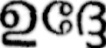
ഉദ്ദേ
